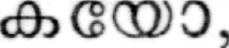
കയോ,
